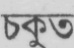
চকুত
